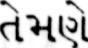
તેમણે
